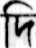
দি
